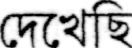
দেখেছি
